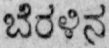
ಬೆರಳಿನ
